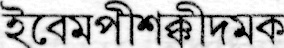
ইবেমপীশক্কীদমক
